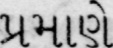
પ્રમાણે
